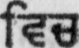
ਵਿਚ
